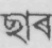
ছাৰ
